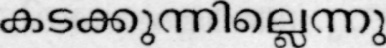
കടക്കുന്നില്ലെന്നു
